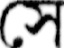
সে
